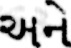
અને
